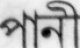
পানী
